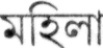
মহিলা
